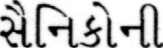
સૈનિકોની
